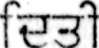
ਦਿਤੀ
